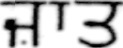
ਜ਼ਾਤ
